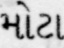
મોટા
